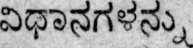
ವಿಧಾನಗಳನ್ನು
